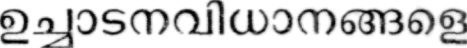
ഉച്ചാടനവിധാനങ്ങളെ
